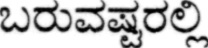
ಬರುವಷ್ಟರಲ್ಲಿ
